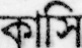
কাসি
